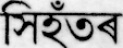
সিহঁতৰ
